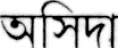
অসিদা
